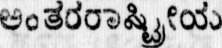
ಅಂತರರಾಷ್ಟ್ರೀಯ
